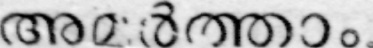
അമര്‍ത്താം.
